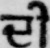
ਦੀ
